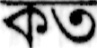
কত
